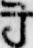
ਹੋ
